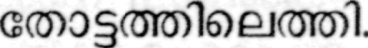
തോട്ടത്തിലെത്തി.
